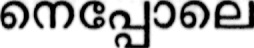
നെപ്പോലെ
